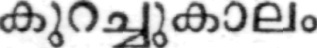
കുറച്ചുകാലം
